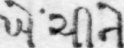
ખેંચીને
